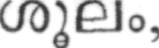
ശൂലം,
